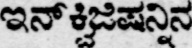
ಇನ್‌ಕ್ವಿಜಿಷನ್ನಿನ
